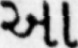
આ
